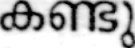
കണ്ടു
